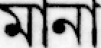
মানা
